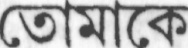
তোমাকে
